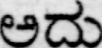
ಅದು
